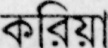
করিয়া
